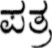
ಪತ್ರ
